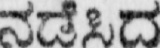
ನಡೆಸಿದ
